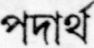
পদার্থ
